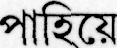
পাহিয়ে
